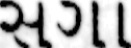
સગા
